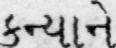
કન્યાને
